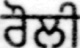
ਰੌਲੀ
